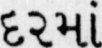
દરમાં
